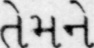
તેમને
